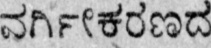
ವರ್ಗೀಕರಣದ
